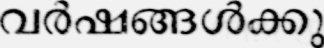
വര്‍ഷങ്ങള്‍ക്കു
